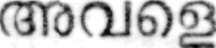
അവളെ
